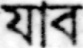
যাব
